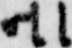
ના
